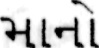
માનો
